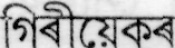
গিৰীয়েকৰ
